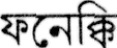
ফনেক্কি
